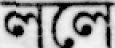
ললে
